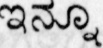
ಇನ್ನೂ
